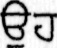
ਉਹ
